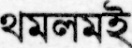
থমলমই
